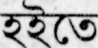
হইতে
